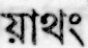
য়াথং
